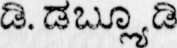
ಡಿ.ಡಬ್ಲ್ಯೂಡಿ
